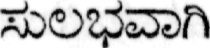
ಸುಲಭವಾಗಿ
